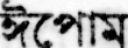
ঈপোম
